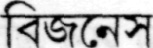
বিজনেস
